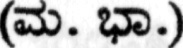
(ಮ.ಭಾ)
